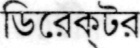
ডিরেক্‌টর
